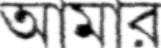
আমার
